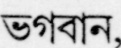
ভগবান,
